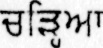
ਚੜ੍ਹਿਆ
